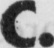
C.
